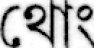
থোং
